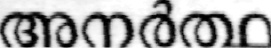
അനര്‍ത്ഥ
